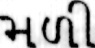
મળી
